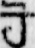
ਹੋ
